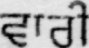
ਵਾਰੀ
